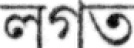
লগত
